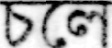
চলে
